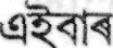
এইবাৰ
